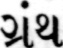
ગ્રંથ
